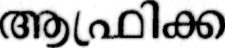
ആഫ്രിക്ക
